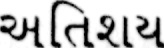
અતિશય
